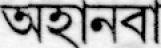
অহানবা
